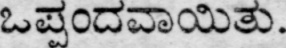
ಒಪ್ಪಂದವಾಯಿತು.
